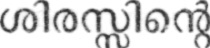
ശിരസ്സിന്റെ
